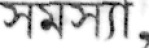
সমস্যা,
